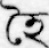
হৈ
